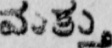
ಮತ್ತು
